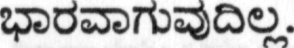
ಭಾರವಾಗುವುದಿಲ್ಲ.
